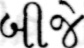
બીજે
